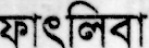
ফাৎলিবা
